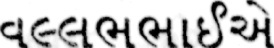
વલ્લભભાઈએ
